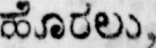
ಹೊರಲು,
